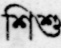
শিশু
